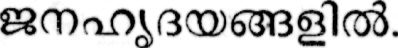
ജനഹൃദയങ്ങളില്‍.
